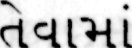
તેવામાં
